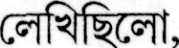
লেখিছিলো,
